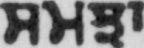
ਸਮਝਾ
